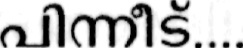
പിന്നീട്....
